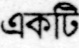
একটি
